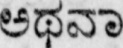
ಅಥವಾ
